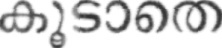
കൂടാതെ
